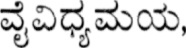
ವೈವಿಧ್ಯಮಯ,
